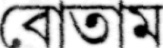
বোতাম
